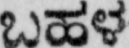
ಬಹಳ
